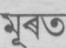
মূৰত
